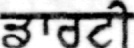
ਡਾਰਟੀ
